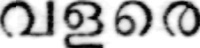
വളരെ
